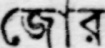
জোর
